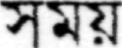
সময়
